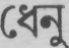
ধেনু
